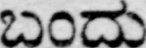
ಬಂದು
